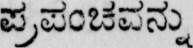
ಪ್ರಪಂಚವನ್ನು
